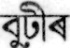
বুঢ়ীৰ
